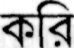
করি
